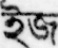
ইজ
